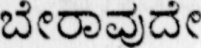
ಬೇರಾವುದೇ
